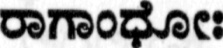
ರಾಗಾಂಧೋಃ
